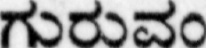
ಗುರುವಂ
